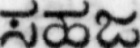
ಸಹಜ
